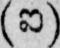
(ಐ)
